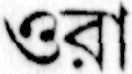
ওরা
